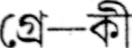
গ্রে–কী
